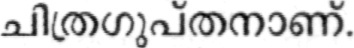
ചിത്രഗുപ്തനാണ്.
